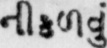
નીકળવું
